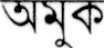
অমুক
